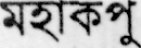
মহাকপু
